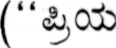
("ಪ್ರಿಯ
